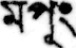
মপূং
